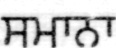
ਸਮਾਨਾ
